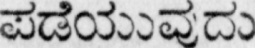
ಪಡೆಯುವುದು
